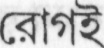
রোগই
